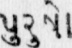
પુરુષો
